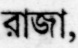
রাজা,
